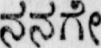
ನನಗೇ
